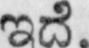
ಇದೆ.
